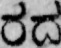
ರದ
